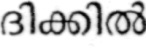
ദിക്കില്‍
